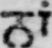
ਨਾਂ
